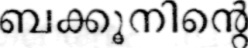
ബക്കൂനിന്റെ
